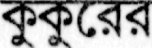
কুকুরের
